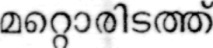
മറ്റൊരിടത്ത്
